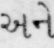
અને
